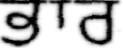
ਭਾਰ
